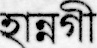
হান্নগী
